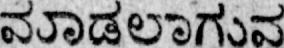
ಮಾಡಲಾಗುವ
